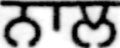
ਨਾਲ
